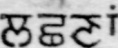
ਲਛਣਾਂ
